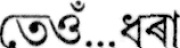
তেওঁ...ধৰা
